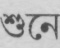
শুনে
